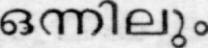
ഒന്നിലും
